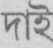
দাই
